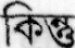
কিন্তু
